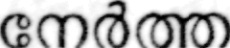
നേര്‍ത്ത
